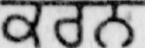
ਕਰਨ
